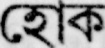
হোক
